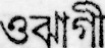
ওঝাগী
